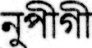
নুপীগী
